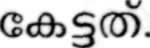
കേട്ടത്.
